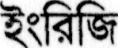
ইংরিজি
